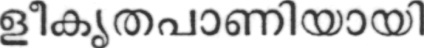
ളീകൃതപാണിയായി
